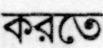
করতে
